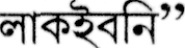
লাকইবনি”
